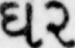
ઘર
